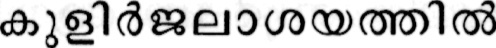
കുളിര്‍ജലാശയത്തില്‍
